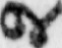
જ
